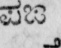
ಪಙ್ತ
